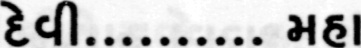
દેવી...........મહા
